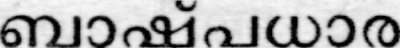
ബാഷ്പധാര
